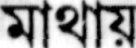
মাথায়
